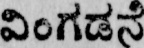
ವಿಂಗಡನೆ
